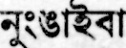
নুংঙাইবা
